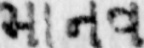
માનવ
